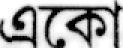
একো
